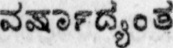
ವರ್ಷಾದ್ಯಂತ
